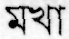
মখা
